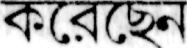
করেছেন
